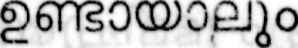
ഉണ്ടായാലും
